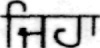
ਜਿਹਾ
